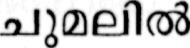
ചുമലില്‍
